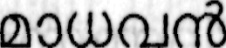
മാധവന്‍
